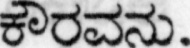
ಕೌರವನು.
